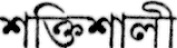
শক্তিশালী
